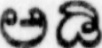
ಅಡಿ
